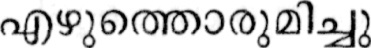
എഴുത്തൊരുമിച്ചു
